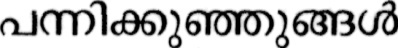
പന്നിക്കുഞ്ഞുങ്ങള്‍
